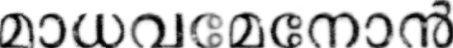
മാധവമേനോന്‍
